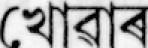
খোৱাৰ
